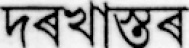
দৰখাস্তৰ
